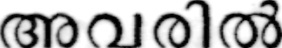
അവരില്‍
